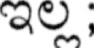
ಇಲ್ಲ;
